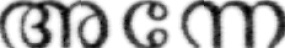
അന്നേ
